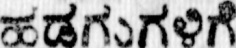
ಹಡಗುಗಳಿಗೆ
